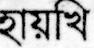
হায়খি
